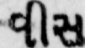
વીસ
